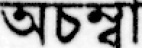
অচম্বা
